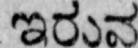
ಇರುವ
